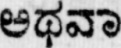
ಅಥವಾ
